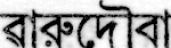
ৱারুদৌবা
